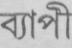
ব্যাপী
